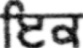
ਇਕ
